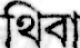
থিবা
